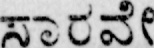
ಸಾರವೇ
